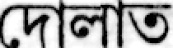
দোলাত
